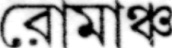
রোমাঞ্চ
